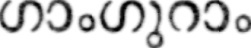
ഗാംഗുറാം
